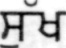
ਸੁੱਖ
